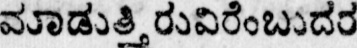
ಮಾಡುತ್ತಿರುವಿರೆಂಬುದರ
